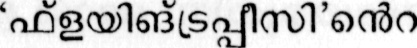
‘ഫ്ളയിങ്ട്രപ്പീസി’ൻെറ
